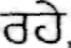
ਰਹੇ,
